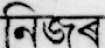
নিজৰ
